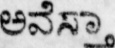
ಅವೆಸ್ತಾ
